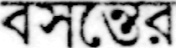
বসন্তের
